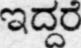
ಇದ್ದರೆ
